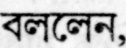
বললেন,
